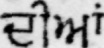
ਦੀਆਂ
